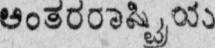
ಅಂತರರಾಷ್ಟ್ರಿಯ
